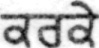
ਕਰਕੇ
